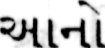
આનો
